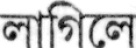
লাগিলে
